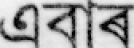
এবাৰ
